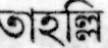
তাহল্লি
